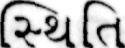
સ્થિતિ
